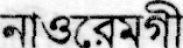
নাওরেমগী
